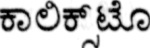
ಕಾಲಿಕ್ಸ್ ಟೊ
